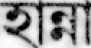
হান্না
